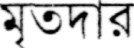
মৃতদার
